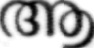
ആ
